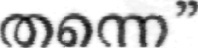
തന്നെ”
